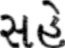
સહે
